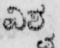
ವಿಶ್ವ
